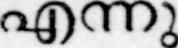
എന്നു
